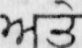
ਅਤੇ
